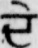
ਦੇ
